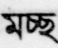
মচ্ছ
